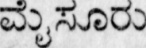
ಮೈಸೂರು
